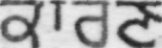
ਕਾਰਣ
